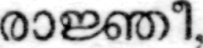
രാജ്ഞീ,
